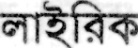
লাইরিক
